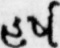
હર્ષ
